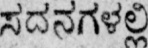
ಸದನಗಳಲ್ಲಿ
